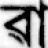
ৱা
